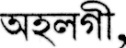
অহলগী,
